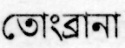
তোংব্রানা
